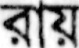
রায়
